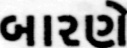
બારણે
